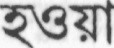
হওয়া
